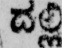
ದಲ್ಲಿ
